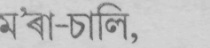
ম'ৰা-চালি,
